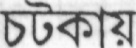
চটকায়
